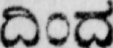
ದಿಂದ
